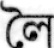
লৈ
